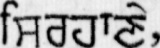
ਸਿਰਹਾਣੇ,
